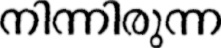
നിന്നിരുന്ന
